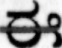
ಈ
